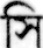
সি
